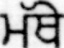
ਮੱਥੇ
